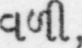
વળી,
